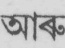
আৰু
